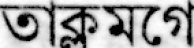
তাক্লমগে
